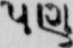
પણ
